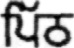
ਪਿੱਠ
